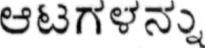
ಆಟಗಳನ್ನು
